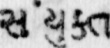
સંયુક્ત
